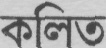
কলিত
